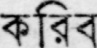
করিব
